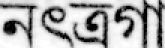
নৎত্রগা
